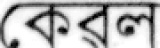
কেৱল
